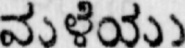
ಮಳೆಯು
